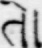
તો
